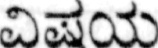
ವಿಷಯ
